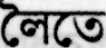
লৈতে
